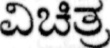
ವಿಚಿತ್ರ
